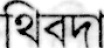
থিবদা
